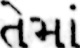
તેમાં
